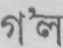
গ'ল
